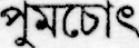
পুমচোৎ
